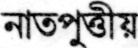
নাতপুত্তীয়
